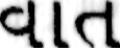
વાત
